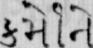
કર્મોને
